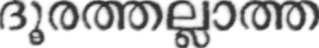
ദൂരത്തല്ലാത്ത
